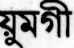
য়ুমগী
